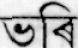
ভৰি
